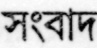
সংবাদ
